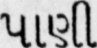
પાણી
